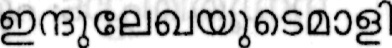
ഇന്ദുലേഖയുടെമാളി
